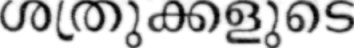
ശത്രുക്കളുടെ
